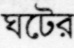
ঘটের
